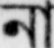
না
